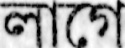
লাগে
